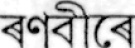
ৰণবীৰে
